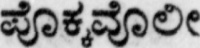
ಪೊಕ್ಕವೊಲೀ
